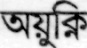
অয়ুক্নি
